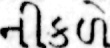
નીકળે
